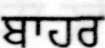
ਬਾਹਰ
